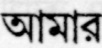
আমার
